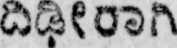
ದಿಢೀರಾಗಿ
